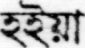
হইয়া
